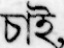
চাই,
